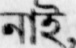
নাই,
